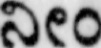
ನೀಂ
